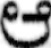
ಆ
